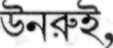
উনরুই,
